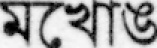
মখোঙ
